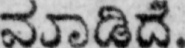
ಮಾಡಿದೆ.
